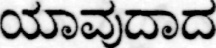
ಯಾವುದಾದ
